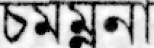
চমম্ননা
